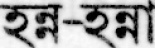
হন্ন-হন্না
